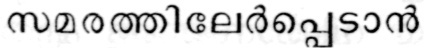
സമരത്തിലേര്‍പ്പെടാന്‍
